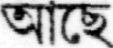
আছে
